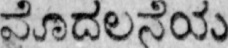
ಮೊದಲನೆಯ
